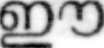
ഈ
